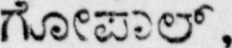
ಗೋಪಾಲ್,
